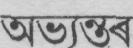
অভ্যন্তৰ
